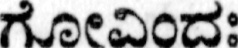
ಗೋವಿಂದಃ
